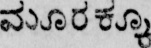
ಮೂರಕ್ಕೂ
